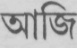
আজি
